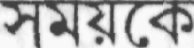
সময়কে
